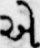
એ
